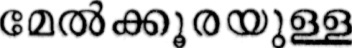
മേല്‍ക്കൂരയുള്ള
